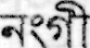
নংগী
